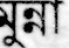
মুন্না
